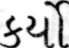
કર્યો
